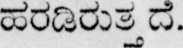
ಹರಡಿರುತ್ತದೆ.
